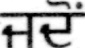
ਜਦੋਂ
